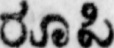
ರೂಪಿ
